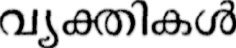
വ്യക്തികള്‍
